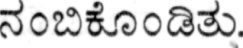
ನಂಬಿಕೊಂಡಿತು.
